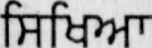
ਸਿਖਿਆ
